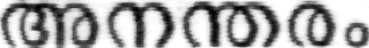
അനന്തരം
